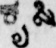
ಕೃಷಿ
